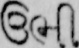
ઉભી
